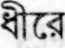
ধীরে
